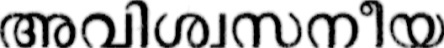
അവിശ്വസനീയ
